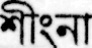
শীংনা
